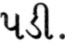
પડી.
